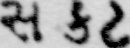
સકટ
